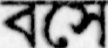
বসে
